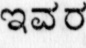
ಇವರ
